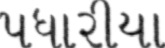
પધારીયા
